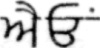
ਐਓਂ
